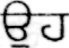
ਉਹ
